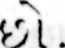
છો.
